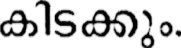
കിടക്കും.
